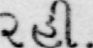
રહી.
